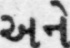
અને
